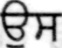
ਉਸ
